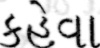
કહેવા
